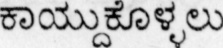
ಕಾಯ್ದುಕೊಳ್ಳಲು
